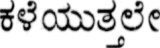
ಕಳೆಯುತ್ತಲೇ
